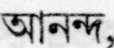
আনন্দ,
